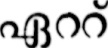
ഏററ്
